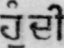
ਹੁੰਦੀ
